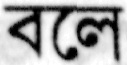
বলে
